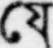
যে
